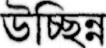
উচ্ছিন্ন
